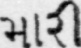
મારી
